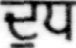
ਦੁਧ
